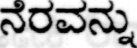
ನೆರವನ್ನು
